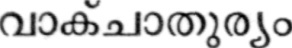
വാക്ചാതുര്യം
